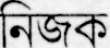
নিজক
